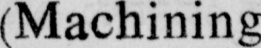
(Machining
